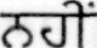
ਨਹੀਂ
